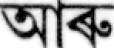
আৰু
